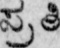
ಪ್ರತಿ
